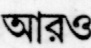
আরও
